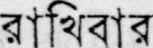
রাখিবার
